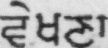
ਵੇਖਣਾ
